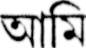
আমি
